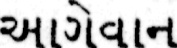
આગેવાન
